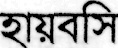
হায়বসি
